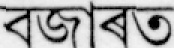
বজাৰত
